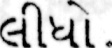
લીધો.
